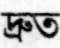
দ্রুত
